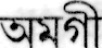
অমগী
